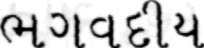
ભગવદીય
